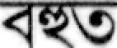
বহুত
